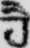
ਹੈ
